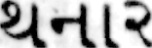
થનાર
